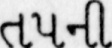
તપની
